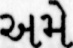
અમે
